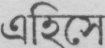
এহিসে
